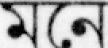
মনে
